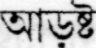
আড়ষ্ট
